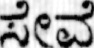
ಸೇವೆ
